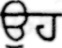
ਉਹ
